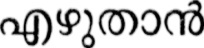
എഴുതാന്‍
